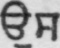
ਉਸ
